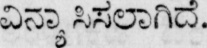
ವಿನ್ಯಾಸಿಸಲಾಗಿದೆ.
